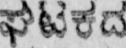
ಘಟಕದ
